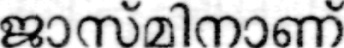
ജാസ്മിനാണ്
